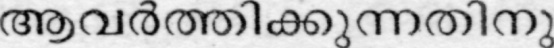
ആവര്‍ത്തിക്കുന്നതിനു
